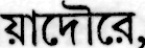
য়াদৌরে,
